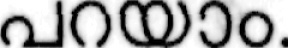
പറയാം.
